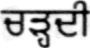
ਚੜ੍ਹਦੀ
